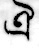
ঐ
